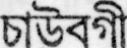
চাউবগী
